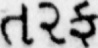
તરફ
